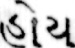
હોય
